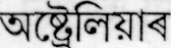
অষ্ট্ৰেলিয়াৰ
